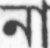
না
